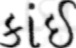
કાંઈ
